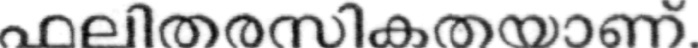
ഫലിതരസികതയാണ്.
